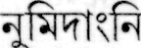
নুমিদাংনি
